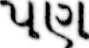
પણ
